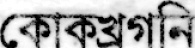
কোকখ্রগনি
